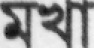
মখা
